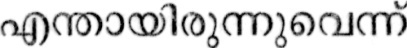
എന്തായിരുന്നുവെന്ന്
